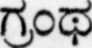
ಗ್ರಂಥ
